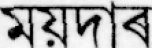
ময়দাৰ
